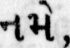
નમે,
